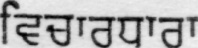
ਵਿਚਾਰਧਾਰਾ
